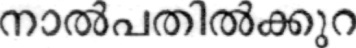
നാല്‍പതില്‍ക്കുറ
